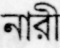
নারী
